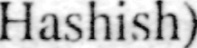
Hashish)
